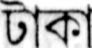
টাকা
